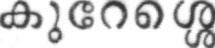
കുറേശ്ശെ
